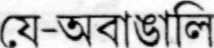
যে-অবাঙালি
